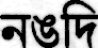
নঙদি
